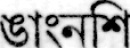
ঙাংনশি
